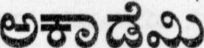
ಅಕಾಡೆಮಿ
